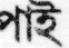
পাই
